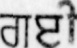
ਗਈ
